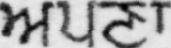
ਅਪਣਾ
